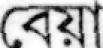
বেয়া
